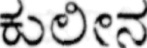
ಕುಲೀನ
